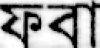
ফবা
